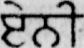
ਏਨੀ
